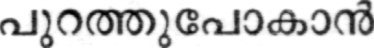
പുറത്തുപോകാന്‍
